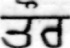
ਤੌਰ
